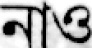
নাও
